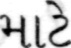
માટે
